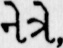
નેત્રે,
